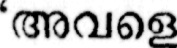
‘അവളെ
